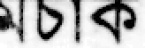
মচাক
